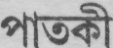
পাতকী
